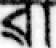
ৱা
